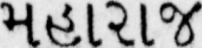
મહારાજ
